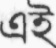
এই
